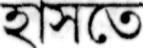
হাসতে
